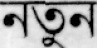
নতুন
